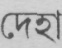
দেহা
